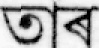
তাৰ
